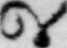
જ
